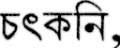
চৎকনি,
